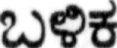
ಬಳಿಕ
